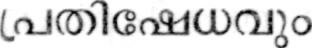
പ്രതിഷേധവും
